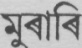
মুৰাৰি
